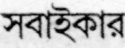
সবাইকার
